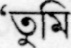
‘তুমি
